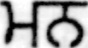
ਮਨ
